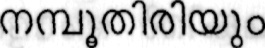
നമ്പൂതിരിയും
